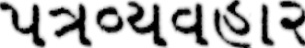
પત્રવ્યવહાર
